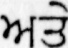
ਅਤੇ
